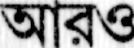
আরও
